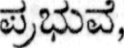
ಪ್ರಭುವೆ,
